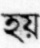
হয়
